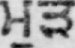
ਮੁੜ
